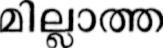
മില്ലാത്ത
